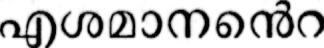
എശമാനന്റെ
